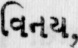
વિનય,
